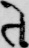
તે
